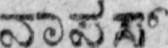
ವಾಪಸ್
